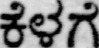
ಕೆಳಗೆ
